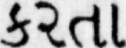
કરતા
